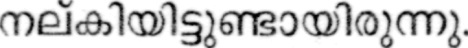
നല്കിയിട്ടുണ്ടായിരുന്നു.
